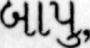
બાપુ,
